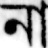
না
